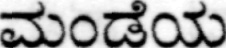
ಮಂಡೆಯ
